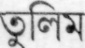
তুলিম
